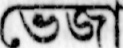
ভেজা
